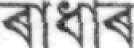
ৰাধাৰ
